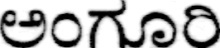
ಅಂಗೂರಿ
